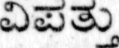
ವಿಪತ್ತು
